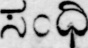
ಸಂಧಿ
